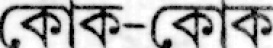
কোক-কোক
